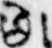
છો
